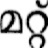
മറ്റ്
